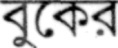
বুকের
